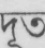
দূত
